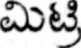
ಮಿಟ್ರಿ
